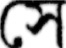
সে
